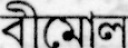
বীমোল
